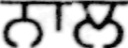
ਨਾਲ
